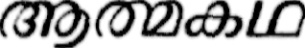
ആത്മകഥ
